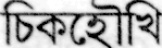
চিকহৌখি
